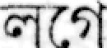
লগে
